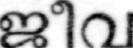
ജീവ
